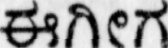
ಈಗೀಗ
